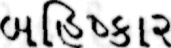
બહિષ્કાર
